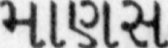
માણસ
